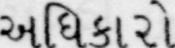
અધિકારો
